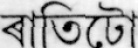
ৰাতিটো
